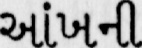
આંખની
